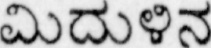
ಮಿದುಳಿನ
